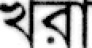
খরা
